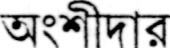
অংশীদার
